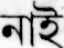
নাই
